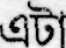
এটা
